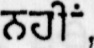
ਨਹੀਂ,
